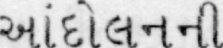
આંદોલનની
